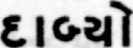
દાબ્યો
